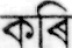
কৰি
